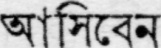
আসিবেন
